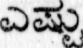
ಎಷ್ಟು
